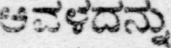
ಅವಳದನ್ನು
